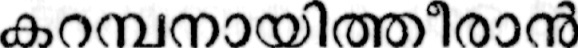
കറമ്പനായിത്തീരാന്‍
